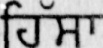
ਹਿੱਸਾ
